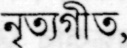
নৃত্যগীত,
